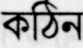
কঠিন
